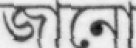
জানো
